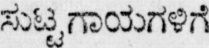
ಸುಟ್ಟಗಾಯಗಳಿಗೆ
